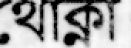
থোক্না
